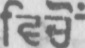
ਵਿਚੋਂ
